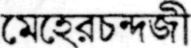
মেহেরচন্দজী
